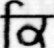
ਕਿ
